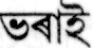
ভৰাই
